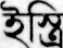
ইস্ত্রি
